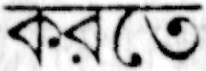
করতে
